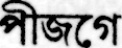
পীজগে
